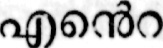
എന്റെ
